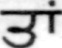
ਤਾਂ
